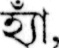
হ্যাঁ,
